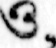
ও,
